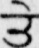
ਤੇ
